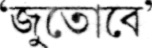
‘জুতোবে’
